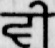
ਵੀ
